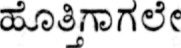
ಹೊತ್ತಿಗಾಗಲೇ
